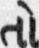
તો
